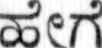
ಹೇಗೆ
